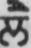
ਲੈ
